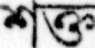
শক্ত
